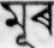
মূৰ
